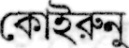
কোইরুনি
